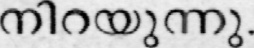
നിറയുന്നു.
